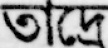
তাদ্রে
